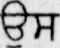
ਉਸ
